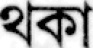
থকা
